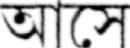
আসে
